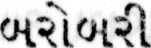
બરોબરી
